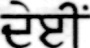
ਦੇਈਂ
